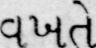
વખતે
